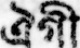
ঐগী
